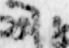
એક
